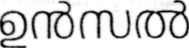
ഉന്‍സല്‍
